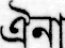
ঐনা
